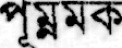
পূম্নমক
